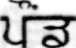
ਪੌਂਡ
